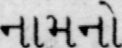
નામનો
